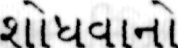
શોધવાનો
